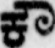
ಕೌ
